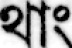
থাং
